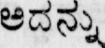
ಅದನ್ನು
